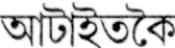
আটাইতকৈ
